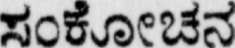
ಸಂಕೋಚನ
